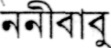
ননীবাবু
